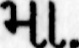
મા.
